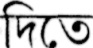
দিতে
